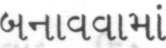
બનાવવામાં
